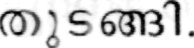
തുടങ്ങി.
